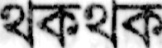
থকথক
